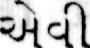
એવી
